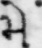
મેં
